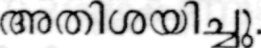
അതിശയിച്ചു.
